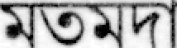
মতমদা
